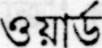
ওয়ার্ড
